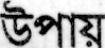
উপায়
